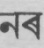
নৰ
